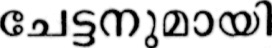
ചേട്ടനുമായി
